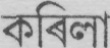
কৰিলা
